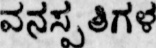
ವನಸ್ಪತಿಗಳ
